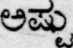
ಅಷ್ಟು
